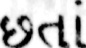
છતાં
